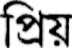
প্রিয়
